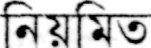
নিয়মিত
